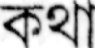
কথা
